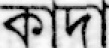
কাদা
